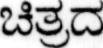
ಚಿತ್ರದ
